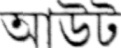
আউট
